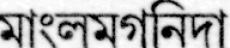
মাংলমগনিদা
